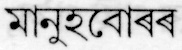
মানুহবোৰৰ
